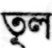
তুল
